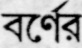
বর্ণের
